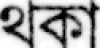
থকা
